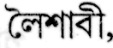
লৈশাবী,
